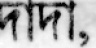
দাদা,
